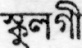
স্কুলগী
